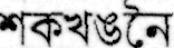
শকখঙনৈ
